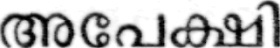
അപേക്ഷി
